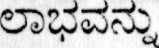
ಲಾಭವನ್ನು
